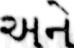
અને
